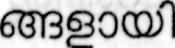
ങ്ങളായി
